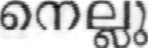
നെല്ലു
